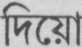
দিয়ো
